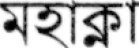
মহাক্না
